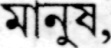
মানুষ,
